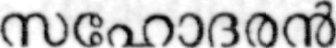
സഹോദരന്‍
